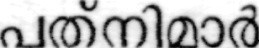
പത്നിമാര്‍
